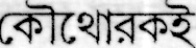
কৌথোরকই
